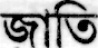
জাতি
